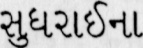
સુધરાઈના
